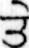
ਤੇ
